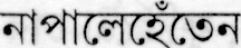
নাপালেহেঁতেন
